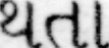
થતા
